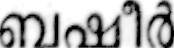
ബഷീര്‍
